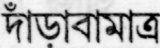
দাঁড়াবামাত্র
